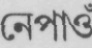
নেপাওঁ
